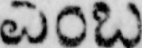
ಎಂಬ
